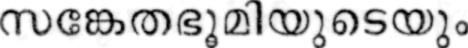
സങ്കേതഭൂമിയുടെയും
